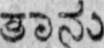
ತಾನು
